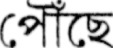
পৌঁছে
